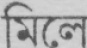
মিলে
